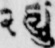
રહ્યું
